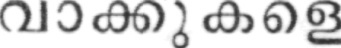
വാക്കുകളെ
